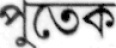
পুতেক
